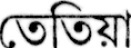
তেতিয়া
